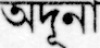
অদূনা
